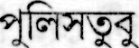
পুলিসতুবু
